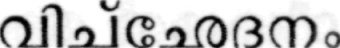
വിച്ഛേദനം
